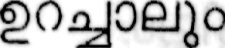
ഉറച്ചാലും
